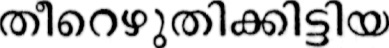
തീറെഴുതിക്കിട്ടിയ
